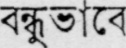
বন্ধুভাবে
